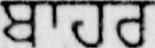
ਬਾਹਰ
